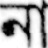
না
